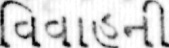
વિવાહની
